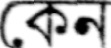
কেন
